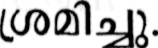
ശ്രമിച്ചു.
